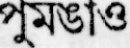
পুমঙাও
